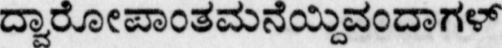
ದ್ವಾರೋಪಾಂತಮನೆಯ್ದಿವಂದಾಗಳ್
